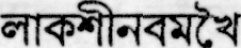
লাকশীনবমখৈ
